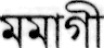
মমাগী
